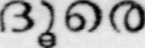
ദൂരെ
